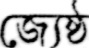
জ্যেষ্ঠ
